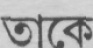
তাকে
